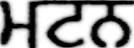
ਮਟਨ
